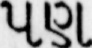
પણ
